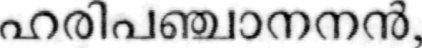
ഹരിപഞ്ചാനനന്‍,
